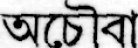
অচৌবা
